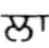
ਲਾ
